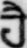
ਹੈ
